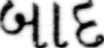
બાદ
